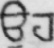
ਉਹ
